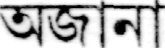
অজানা
